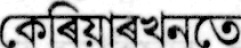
কেৰিয়াৰখনতে
